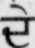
ਦੇ
